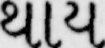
થાય
